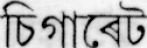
চিগাৰেট
